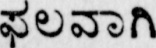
ಫಲವಾಗಿ
